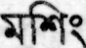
মশিং
